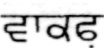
ਵਾਕਫ਼
